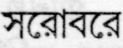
সরোবরে
